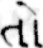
તો
